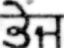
ਭੇਜ
